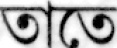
তাতে
